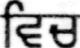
ਵਿਚ
